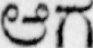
ಆಗ
